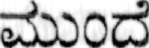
ಮುಂದೆ
